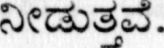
ನೀಡುತ್ತವೆ.
